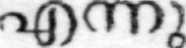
എന്നു
